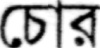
চোর
